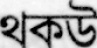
থকউ
